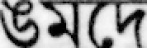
ঙমদে
